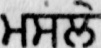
ਮਸਲੇ
